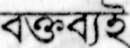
বক্তব্যই
